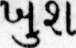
ખુશ
